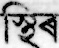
স্থিৰ
